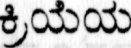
ಕ್ರಿಯೆಯ
